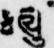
કહ્યું
